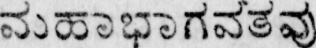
ಮಹಾಭಾಗವತವು
